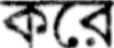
করে
